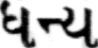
ધન્ય
